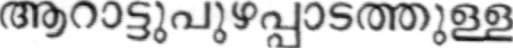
ആറാട്ടുപുഴപ്പാടത്തുള്ള
